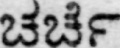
ಚರ್ಚೆ
